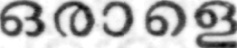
ഒരാളെ
